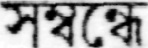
সম্বন্ধে
